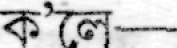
ক'লে-
